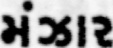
મંઝાર
